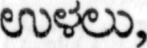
ಉಳಲು,
